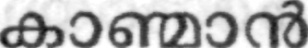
കാണ്മാന്‍
